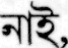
নাই,
